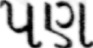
પણ
